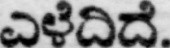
ಎಳೆದಿದೆ.
